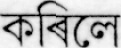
কৰিলে
